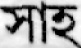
সাহ
